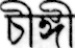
চীঙ্গী
